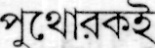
পুথোরকই
